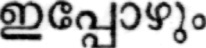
ഇപ്പോഴും
